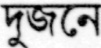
দুজনে
